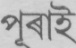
পূৰাই
